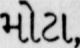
મોટા,
